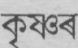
কৃষ্ণৰ
